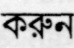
করুন
